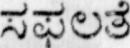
ಸಫಲತೆ
